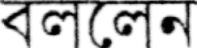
বললেন
